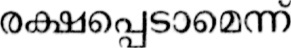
രക്ഷപ്പെടാമെന്ന്
